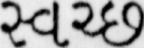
સ્વચ્છ
